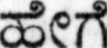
ಹೇಗೆ
